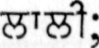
ਲਾਲੀ;
